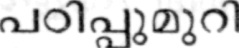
പഠിപ്പുമുറി
